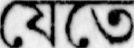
যেতে
